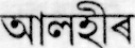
আলহীৰ
